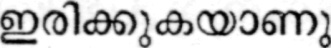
ഇരിക്കുകയാണു
